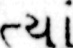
ત્યાં
